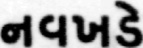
નવખડે
